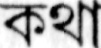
কথা
